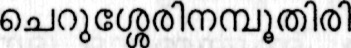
ചെറുശ്ശേരിനമ്പൂതിരി
